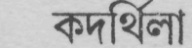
কদৰ্থিলা
